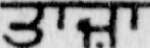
ਤਾਜ਼ਾ
